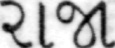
રાજા
